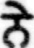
ਨੇ
